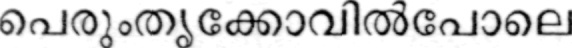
പെരുംതൃക്കോവില്‍പോലെ
